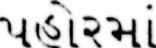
પહોરમાં
